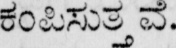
ಕಂಪಿಸುತ್ತವೆ.
